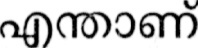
എന്താണ്
